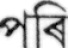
পৰি
